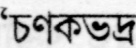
‘চণকভদ্র
